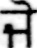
ਜੋ
